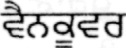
ਵੈਨਕੂਵਰ
